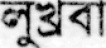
লুখ্রবা
